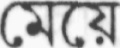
মেয়ে
